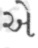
એ
